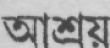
আশ্ৰয়
